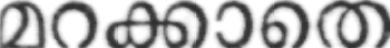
മറക്കാതെ
